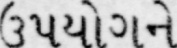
ઉપયોગને
